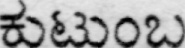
ಕುಟುಂಬ
